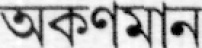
অকণমান
